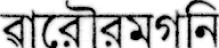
ৱারৌরমগনি
